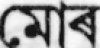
মোৰ
